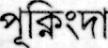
পূক্নিংদা
